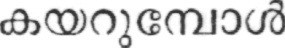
കയറുമ്പോള്‍
